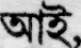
আই,
